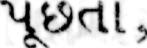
પૂછતા,
